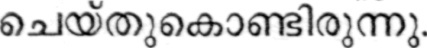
ചെയ്തുകൊണ്ടിരുന്നു.
